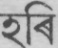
হৰি
